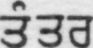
ਤੰਤਰ
